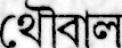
থৌবাল
